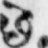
છએ.
